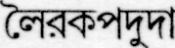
লৈরকপদুদা
